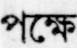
পক্ষে
